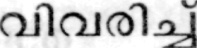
വിവരിച്ച്
